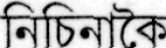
নিচিনাকৈ
